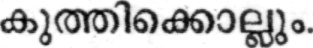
കുത്തിക്കൊല്ലും.
